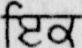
ਇਕ
